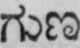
ಗುಣ
